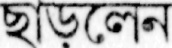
ছাড়লেন
